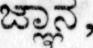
ಜ್ಞಾನ,
